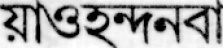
য়াওহন্দনবা
